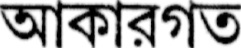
আকারগত
